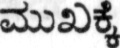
ಮುಖಕ್ಕೆ
